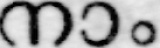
നാം
